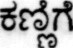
ಕಣ್ಣಿಗೆ
